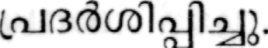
പ്രദര്‍ശിപ്പിച്ചു.
